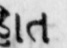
હોત
